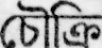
চৌক্রি
